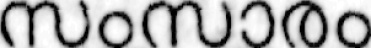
സംസാരം
